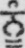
ਨੂੰ
